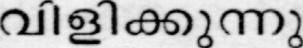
വിളിക്കുന്നു
